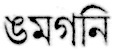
ঙমগনি
